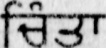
ਚਿੰਤਾ
